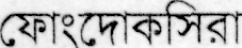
ফোংদোকসিরা
